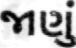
જાણું
